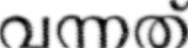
വന്നത്
